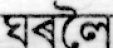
ঘৰলৈ
